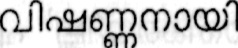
വിഷണ്ണനായി
